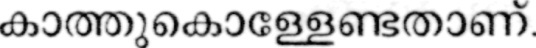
കാത്തുകൊള്ളേണ്ടതാണ്.
